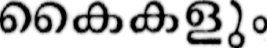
കൈകളും
